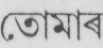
তোমাৰ
